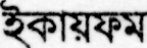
ইকায়ফম
